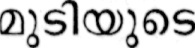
മുടിയുടെ
